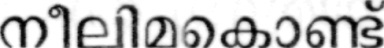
നീലിമകൊണ്ട്
